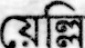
য়েল্লি
